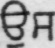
ਉਸ
